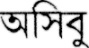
অসিবু
